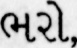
ભરો,
